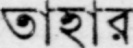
তাহার
